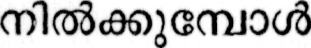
നില്‍ക്കുമ്പോള്‍
